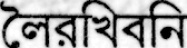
লৈরখিবনি
